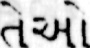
તેઓ
